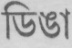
ডিঙা
